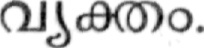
വ്യക്തം.
